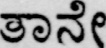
ತಾನೇ
